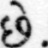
છે.
